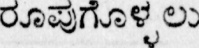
ರೂಪುಗೊಳ್ಳಲು
